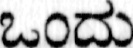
ಒಂದು
